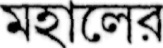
মহালের
